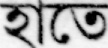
হাতে
